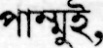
পাম্মুই,
